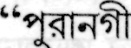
“পুরানগী
